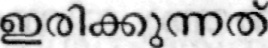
ഇരിക്കുന്നത്
